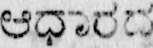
ಆಧಾರದ
